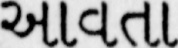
આવતા
